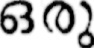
ഒരു
